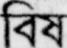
বিষ
